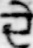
ਦੇ
